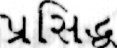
પ્રસિદ્ધિ
